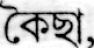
কৈছা,
